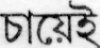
চায়েই
